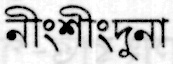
নীংশীংদুনা
